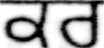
ਕਰ
